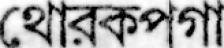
থোরকপগা
